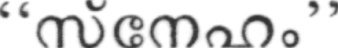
"സ്നേഹം"
